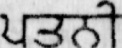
ਪਤਨੀ
